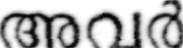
അവര്‍
